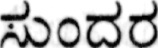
ಸುಂದರ
